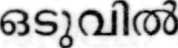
ഒടുവില്‍
